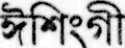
ঈশিংগী
